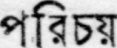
পরিচয়
